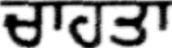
ਚਾਹਤਾ
